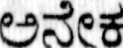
ಅನೇಕ
